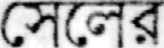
সেলের
